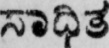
ಸಾಧಿತ
